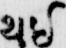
થઈ
